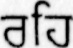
ਰਹਿ
